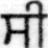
ਸੀ
